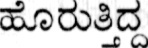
ಹೊರುತ್ತಿದ್ದ
